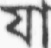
যা
